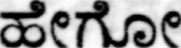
ಹೇಗೋ
